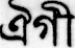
ঐগী
